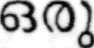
ഒരു
